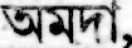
অমদা,
